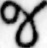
જ
